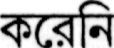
করেনি
